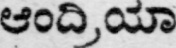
ಆಂದ್ರಿಯಾ
